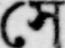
সে
